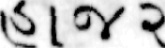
હાજર
